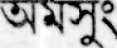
অমসুং
